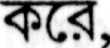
করে,
